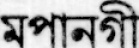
মপানগী
